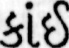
કાંઈ
